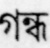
গন্ধ
